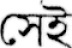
সেই
